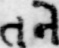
તને
